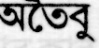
অতৈবু
